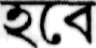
হবে
